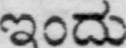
ಇಂದು
